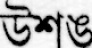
উশঙ
